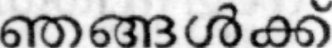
ഞങ്ങള്‍ക്ക്
